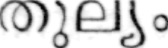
തുല്യം
